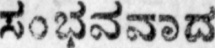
ಸಂಭವವಾದ
